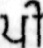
ਪੀ
